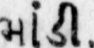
માંડી.
